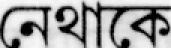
নেথাকে
